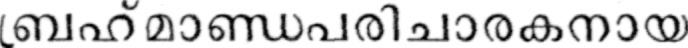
ബ്രഹ്മാണ്ഡപരിചാരകനായ
